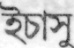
ইচাসু
